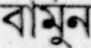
বামুন
